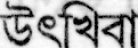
উৎখিবা
